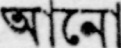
আনো
